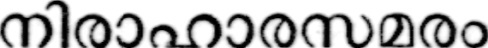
നിരാഹാരസമരം
